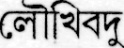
লৌখিবদু
